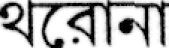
থরোনা
